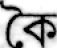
কৈ
